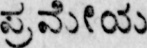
ಪ್ರಮೇಯ
